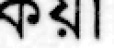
কয়া
